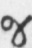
જ
